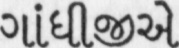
ગાંઘીજીએ
